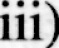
iii)
